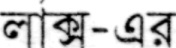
লাক্স-এর
